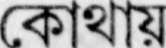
কোথায়
